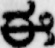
ಈ
